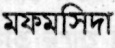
মফমসিদা
